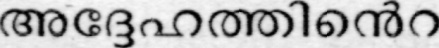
അദ്ദേഹത്തിന്റെ
